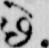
છે.
